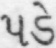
પડે
